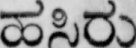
ಹಸಿರು
